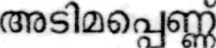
അടിമപ്പെണ്ണ്
